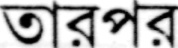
তারপর
